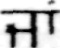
ਜਾਂ
